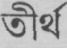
তীৰ্থ
